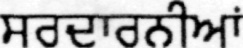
ਸਰਦਾਰਨੀਆਂ
